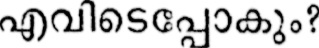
എവിടെപ്പോകും?
